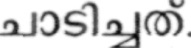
ചാടിച്ചത്.
